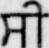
ਸੀ
